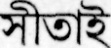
সীতাই
